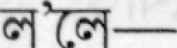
ল'লে-
